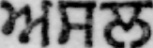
ਅਸਲ
